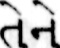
તેને
